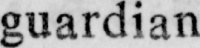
guardian
